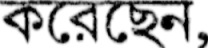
করেছেন,
